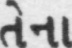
તેના
